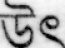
উৎ
